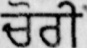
ਚੋਰੀ
